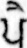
ਪੈ
